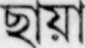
ছায়া
